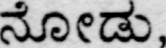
ನೋಡು,
